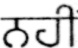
ਨਹੀਂ
